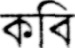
কবি
